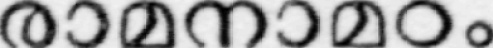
രാമനാമഠം
